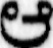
ಆ
